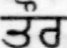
ਤੌਰ
